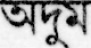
অদুম
